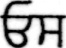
ਓਸ
